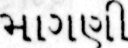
માગણી
